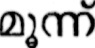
മൂന്ന്
